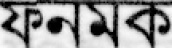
ফনমক
